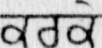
ਕਰਕੇ
